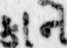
કાને
